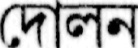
দোলন
